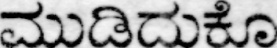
ಮುಡಿದುಕೊ
